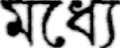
মধ্যে
